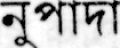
নুপাদা
